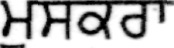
ਮੁਸਕਰਾ
